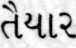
તૈયાર
